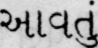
આવતું
